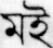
মই
